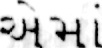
એમાં
